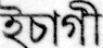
ইচাগী
